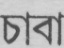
চাবা
